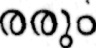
രരും
